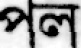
পল
